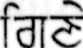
ਗਿਣੇ
